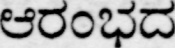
ಆರಂಭದ
